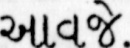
આવજે.
